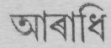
আৰাধি
